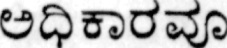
ಅಧಿಕಾರವೂ
